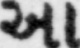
આ
